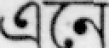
এনে
